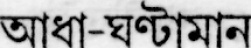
আধা-ঘণ্টামান
